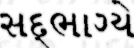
સદ્ભાગ્યે
